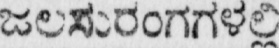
ಜಲಸುರಂಗಗಳಲ್ಲಿ
